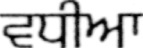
ਵਧੀਆ
